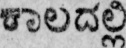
ಕಾಲದಲ್ಲಿ
